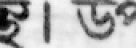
ডপ
